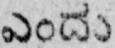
ಎಂದು
